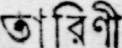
তারিণী
